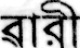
ৱারী
